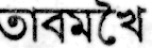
তাবমখৈ
